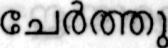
ചേര്‍ത്തു
